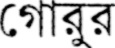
গোরুর
